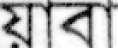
য়াবা
